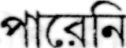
পারেনি
